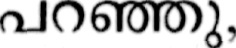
പറഞ്ഞു,
